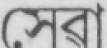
সেৱা
